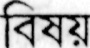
বিষয়
